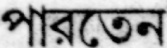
পারতেন
